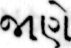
જાણે
